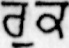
ਰੁਕ
